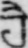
ਹੈ
